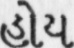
હોય
